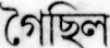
গৈছিল
